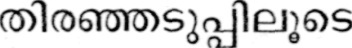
തിരഞ്ഞടുപ്പിലൂടെ
